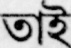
তাই
